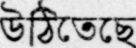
উঠিতেছে
